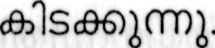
കിടക്കുന്നു.
